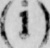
(i)
